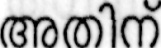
അതിന്
